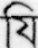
যি
